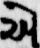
એ
